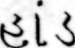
હાંડ
